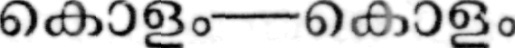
കൊളം-കൊളം
